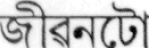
জীৱনটো
